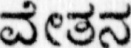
ವೇತನ
